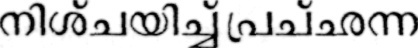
നിശ്ചയിച്ച്പ്രച്ഛന്ന
